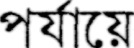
পর্যায়ে
